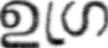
ഉഗ്ര
